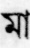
মা
